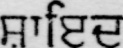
ਸ਼ਾਇਦ
